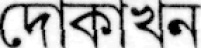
দোকাখন
